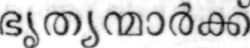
ഭൃത്യന്മാര്‍ക്ക്
